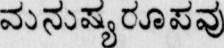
ಮನುಷ್ಯರೂಪವು
